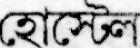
হোস্টেল
